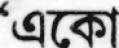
'একো
